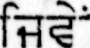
ਜਿਵੇਂ
